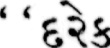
"દરેક
